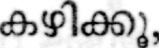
കഴിക്കൂ,
